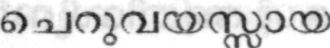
ചെറുവയസ്സായ
